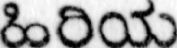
ಹಿರಿಯ
